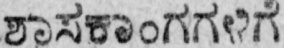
ಶಾಸಕಾಂಗಗಳಿಗೆ
